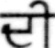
ਦੀ
